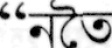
“নতৈ
